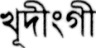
খূদীংগী
